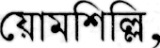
য়োমশিল্লি,
